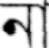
না
